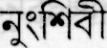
নুংশিবী
